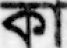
কা
